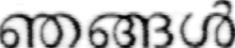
ഞങ്ങള്‍
